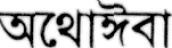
অথোঈবা
